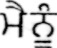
ਮੈਨੂੰ
